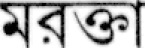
মরক্তা
